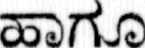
ಹಾಗೂ
